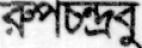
রুপচন্দ্রবু
